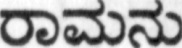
ರಾಮನು
